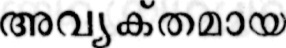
അവ്യക്തമായ
